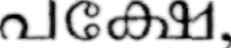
പക്ഷേ,
